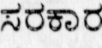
ಸರಕಾರ
